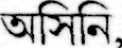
অসিনি,
